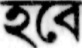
হবে
